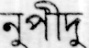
নুপীদু
